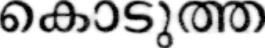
കൊടുത്ത
